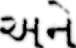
અને
